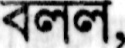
বলল,
